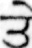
ਤੇ
